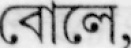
বোলে,
